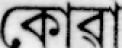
কোৱা
